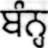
ਬੰਨ੍ਹ
